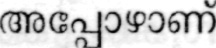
അപ്പോഴാണ്
